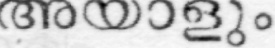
അയാളും
